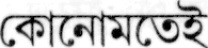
কোনোমতেই
